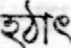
হঠাৎ
